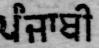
ਪੰਜਾਬੀ
